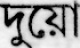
দুয়ো
